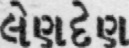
લેણદેણ
